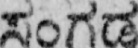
ಸಂಗಡ
